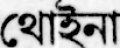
থোইনা
